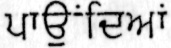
ਪਾਉਂਦਿਆਂ
